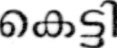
കെട്ടി
